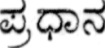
ಪ್ರಧಾನ
